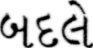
બદલે
